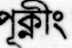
পূক্নীং
